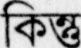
কিন্তু
